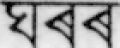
ঘৰৰ
